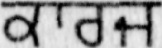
ਕਾਰਜ
